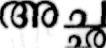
അച്ഛ
